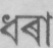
ধৰা
